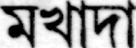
মখাদা
